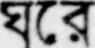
ঘরে
